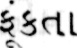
ફુંકતા
